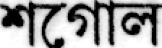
শগোল
